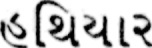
હથિયાર
